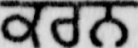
ਕਰਨ
